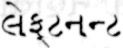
લેફ્ટનન્ટ
